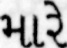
મારે
